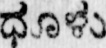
ಧೂಳು
